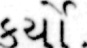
કર્યો.
